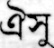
ঐসু
